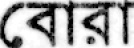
বোরা
